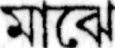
মাঝে
